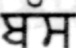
ਬੱਸ
